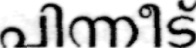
പിന്നീട്
